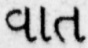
વાત
